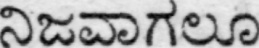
ನಿಜವಾಗಲೂ
